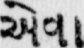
એવા
